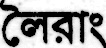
লৈরাং
